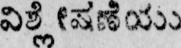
ವಿಶ್ಲೇಷಣೆಯು
